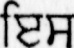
ਇਸ
